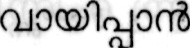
വായിപ്പാന്‍
